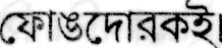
ফোঙদোরকই।
